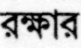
রক্ষার
